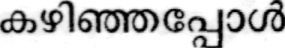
കഴിഞ്ഞപ്പോള്‍
